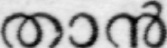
താന്‍
